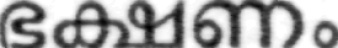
ഭക്ഷണം
